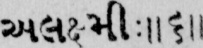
અલક્ષ્મી:||૬||
